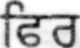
ਫਿਰ
